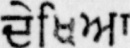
ਦੇਖਿਆ
